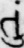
તું
